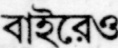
বাইরেও
